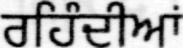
ਰਹਿੰਦੀਆਂ
